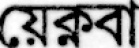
য়েক্নবা
